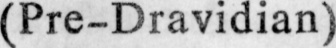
(Pre-Dravidian)
